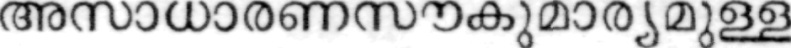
അസാധാരണസൌകുമാര്യമുള്ള
